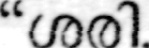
“ശരി.
